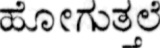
ಹೋಗುತ್ತಲೆ
